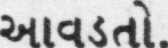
આવડતો.
